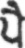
ਪੈ
